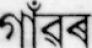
গাঁৱৰ
